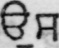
ਉਸ
